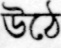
উঠে
